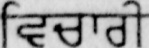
ਵਿਚਾਰੀ
